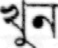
খুন
